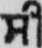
ਸੀ
